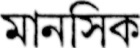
মানসিক
